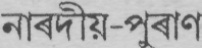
নাৰদীয়-পুৰাণ
